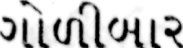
ગોળીબાર
